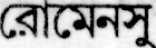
রোমেনবু
